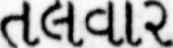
તલવાર
